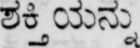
ಶಕ್ತಿಯನ್ನು
